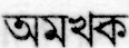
অমখক
